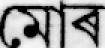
মোৰ
